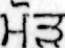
ਮੋੜ
